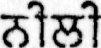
ਨੀਲੀ
